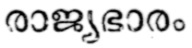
രാജ്യഭാരം
